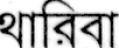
থারিবা
